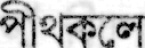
পীথকলে
